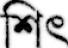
শিৎ
